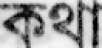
কথা
